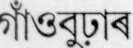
গাঁওবুঢ়াৰ
